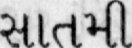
સાતમી
